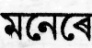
মনেৰে
